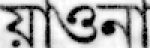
য়াওনা
